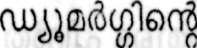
ഡ്യൂമര്‍ഗ്ഗിന്റെ
